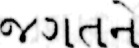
જગતને
